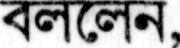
বললেন,
